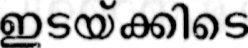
ഇടയ്ക്കിടെ
